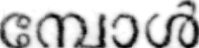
മ്പോള്‍
